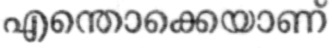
എന്തൊക്കെയാണ്
